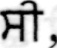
ਸੀ,
